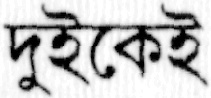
দুইকেই
